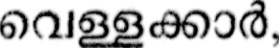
വെള്ളക്കാര്‍,
